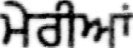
ਮੇਰੀਆਂ
